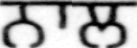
ਨਾਲ
